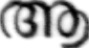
ആ
